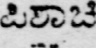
ಪಿಶಾಚಿ
